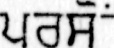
ਪਰਸੋਂ
